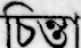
চিন্তা
